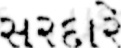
સરદારે
